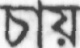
চায়
